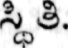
ಸ್ಥಿತಿ.
